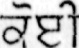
ਕੋਈ
